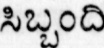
ಸಿಬ್ಬಂದಿ
